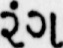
રંગ
